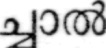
ച്ചാല്‍
